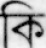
কি
